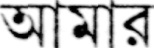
আমার
